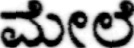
ಮೇಲೆ
